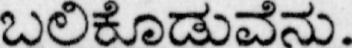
ಬಲಿಕೊಡುವೆನು.
